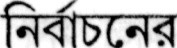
নির্বাচনের
